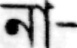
না-
